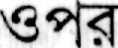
ওপর
